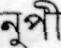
নুপী
